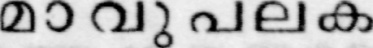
മാവുപലക
